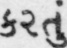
કરતું
